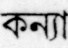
কন্যা
